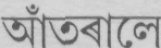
আঁতৰালে
